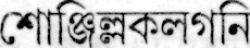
শোঞ্জিল্লকলগনি
